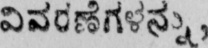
ವಿವರಣೆಗಳನ್ನು,
